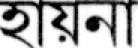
হায়না
